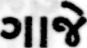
ગાજે
